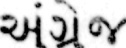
અંગ્રેજ
